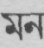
মন
